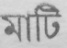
মাটি
